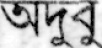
অদুবু
